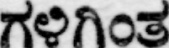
ಗಳಿಗಿ೦ತ
